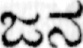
ಜನ
